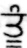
ਤੂੰ
